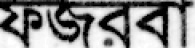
ফজরবা
